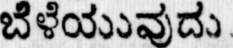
ಬೆಳೆಯುವುದು
